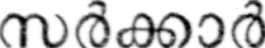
സര്‍ക്കാര്‍
